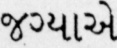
જગ્યાએ
